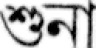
শুনা
